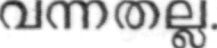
വന്നതല്ല.
